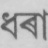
ধৰা
